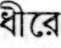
ধীরে
